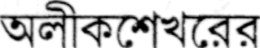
অলীকশেখরের
